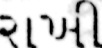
રાખી
